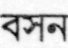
বসন
